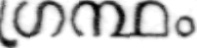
ഗ്രന്ഥം
